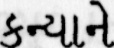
કન્યાને
